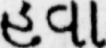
હવા
